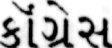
કૉંગ્રેસ
